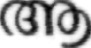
ആ
